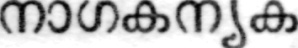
നാഗകന്യക
